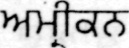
ਅਮ੍ਰੀਕਨ
